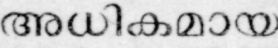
അധികമായ
